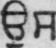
ਉਸ
